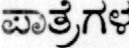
ಪಾತ್ರೆಗಳ
